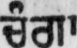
ਚੰਗਾ
